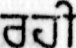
ਰਹੀ
